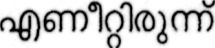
എണീറ്റിരുന്ന്
